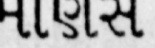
માણસ
